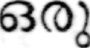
ഒരു
